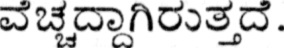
ವೆಚ್ಚದ್ದಾಗಿರುತ್ತದೆ.
